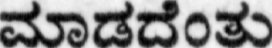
ಮಾಡದೆಂತು
